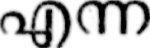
എന്ന
